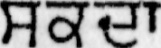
ਸਕਦਾ
